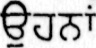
ਉਹਨਾਂ
